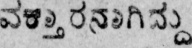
ವಕ್ತಾರನಾಗಿದ್ದು
